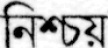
নিশ্চয়
